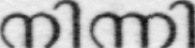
നിന്നി
